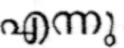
എന്നു
